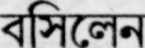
বসিলেন
